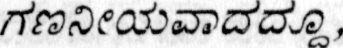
ಗಣನೀಯವಾದದ್ದೂ,
